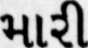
મારી
